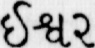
ઈશ્વર
